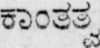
ಕಾಂತತ್ವ
